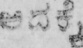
ಅದಕ್ಕೆ
